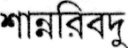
শান্নরিবদু
